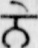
ਨੇ
